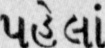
પહેલાં
